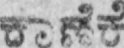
ಕಾಣಿಕೆ
